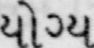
યોગ્ય
